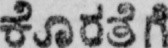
ಕೊರತೆಗೆ
